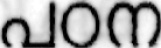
പഠന
